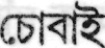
চোবাই
